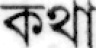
কথা
